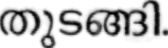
തുടങ്ങി.
